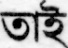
তাই
